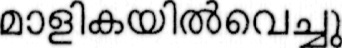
മാളികയില്‍വെച്ചു
